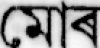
মোৰ
